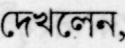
দেখলেন,
